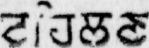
ਟਹਿਲਣ
